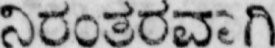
ನಿರಂತರವಾಗಿ
